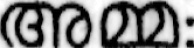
അമ്മ:
